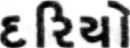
દરિયો
